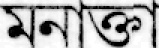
মনাক্তা
